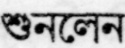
শুনলেন
